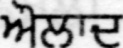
ਔਲਾਦ
